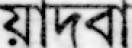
য়াদবা
